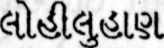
લોહીલુહાણ
